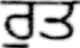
ਰੁਤ
